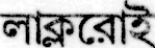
লাক্লরোই
